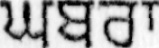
ਘਬਰਾ
